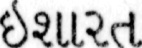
ઇશારત
